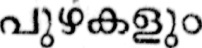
പുഴകളും
